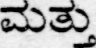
ಮತ್ತು
